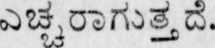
ಎಚ್ಚರಾಗುತ್ತದೆ.
